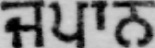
ਜਪਾਨ
